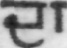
ਦਾ
